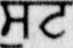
ਸੁਟ
